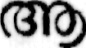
ആ
